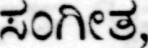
ಸಂಗೀತ,
